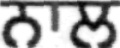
ਨਾਲ
